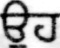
ਉਹ
